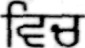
ਵਿਚ
